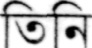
তিনি
